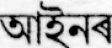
আইনৰ
